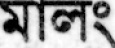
মালং
